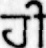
ਹੀ
